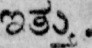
ಇತ್ತು.
